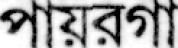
পায়রগা
